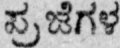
ಪ್ರಜೆಗಳ
